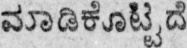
ಮಾಡಿಕೊಟ್ಟಿದೆ
